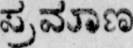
ಪ್ರಮಾಣ
